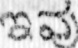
ಇವು
